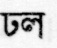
ঢল
